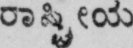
ರಾಷ್ಟ್ರೀಯ
